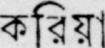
করিয়া
